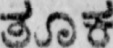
ತೂಕ
